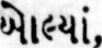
બોલ્યાં,
